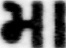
મા
